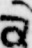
ਕੇ
